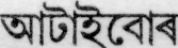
আটাইবোৰ
